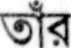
তাঁর
